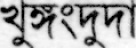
খুঙ্গংদুদা
